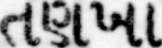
તણખા
